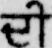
ਦੀ
